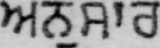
ਅਨੁਸਾਰ
